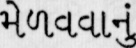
મેળવવાનું
